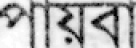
পায়বা
